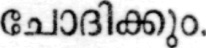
ചോദിക്കും.
